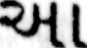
આ
